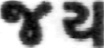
જય
